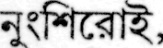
নুংশিরোই,
